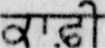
ਕਾਫ਼ੀ
